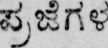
ಪ್ರಜೆಗಳ
